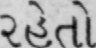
રહેતો
